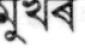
মুখৰ
